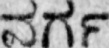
ವರ್ಗ
